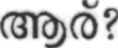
ആര്?
